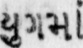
યુગમાં
